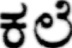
ಕಲೆ
